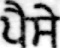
ਪੈਸੇ
